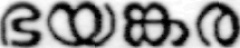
ഭയങ്കര
